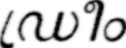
ഡ്രീം
